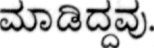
ಮಾಡಿದ್ದವು.
